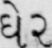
ઘેર
